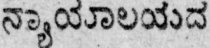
ನ್ಯಾಯಾಲಯದ
